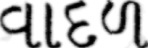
વાદળ
